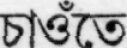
চাওঁতে
